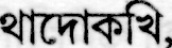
থাদোকখি,
